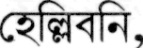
হেল্লিবনি,
